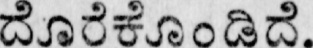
ದೊರೆಕೊಂಡಿದೆ.
